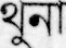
থুনা
